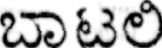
ಬಾಟಲಿ
